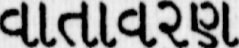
વાતાવરણ
